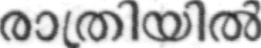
രാത്രിയില്‍
